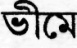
ভীমে
